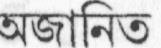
অজানিত
